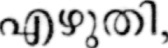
എഴുതി,
